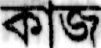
কাজ
